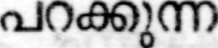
പറക്കുന്ന
